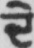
ਦੇ
